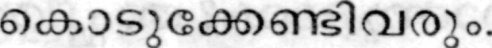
കൊടുക്കേണ്ടിവരും.
